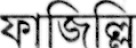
ফাজিল্লি
